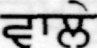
ਵਾਲੇ
